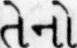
તેનો
